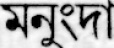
মনুংদা
